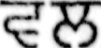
ਵਲ
